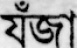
যঁজা
